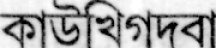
কাউখিগদবা
